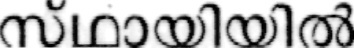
സ്ഥായിയില്‍
